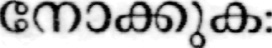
നോക്കുക:
